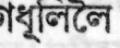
গধূলিলৈ
